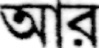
আর
